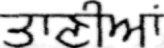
ਤਾਣੀਆਂ
